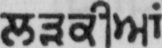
ਲੜਕੀਆਂ
